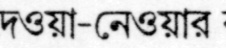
দেওয়া-নেওয়ার
